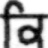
ਕਿ
